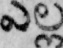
ಎಲ್ಲ
